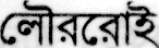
লৌররোই
